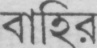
বাহির
